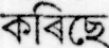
কৰিছে
